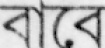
বাবে
